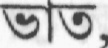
ভাত,
